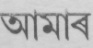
আমাৰ
